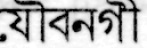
যৌবনগী
